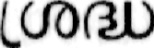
ശ്രദ്ധ
